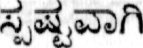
ಸ್ಪಷ್ಟವಾಗಿ
